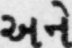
અને
